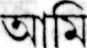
আমি
